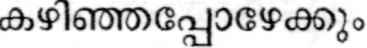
കഴിഞ്ഞപ്പോഴേക്കും
